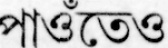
পাওঁতেও
